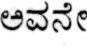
ಅವನೇ
